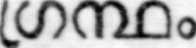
ഗ്രന്ഥം
